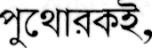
পুথোরকই,
